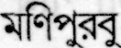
মণিপুরবু
